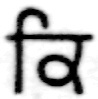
ਕਿ
